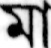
মা
